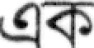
এক
